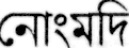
নোংমদি
